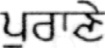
ਪੁਰਾਣੇ
